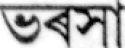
ভৰসা
